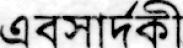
এবসার্দকী
